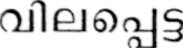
വിലപ്പെട്ട
